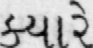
ક્યારે
